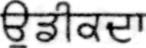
ਉਡੀਕਦਾ
